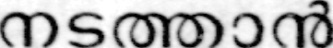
നടത്താന്‍
